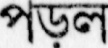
পড়ল
